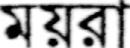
ময়রা
